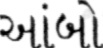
આંબો
